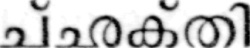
ച്ഛക്തി
